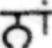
ਨਾਂ
